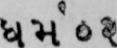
ધર્મ.૨
